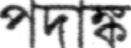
পদাঙ্ক
